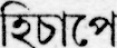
হিচাপে
